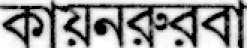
কায়নরুরবা
